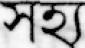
সহ্য
